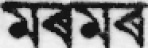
মৰমৰ
